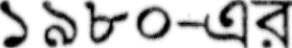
১৯৮০-এর
